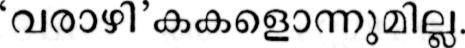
'വരാഴി'കകളൊന്നുമില്ല.
